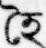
হৈ
